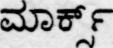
ಮಾರ್ಕ್ಸ್
